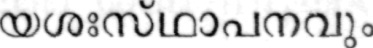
യശഃസ്ഥാപനവും
